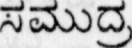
ಸಮುದ್ರ
